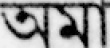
অমা
